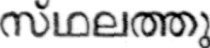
സ്ഥലത്തു
